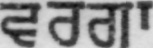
ਵਰਗਾ
